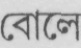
বোলে
